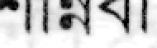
শান্নবা
